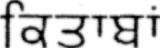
ਕਿਤਾਬਾਂ
